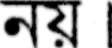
নয়।
